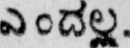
ಎಂದಲ್ಲ.
